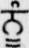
ਨੂੰ
